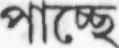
পাচ্ছে
